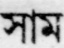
সাম
